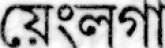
য়েংলগা
